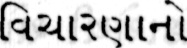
વિચારણાનો
